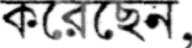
করেছেন,
